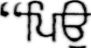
''ਪਿਉ
